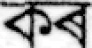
কৰ
